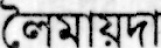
লৈমায়দা
